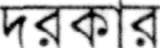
দরকার
